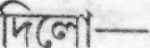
দিলো--
